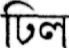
ঢিল
